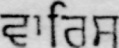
ਵਾਰਿਸ
